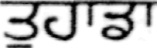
ਤੁਹਾਡਾ
